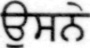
ਉਸਨੇ
